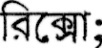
রিক্সো;
